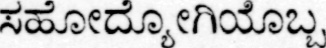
ಸಹೋದ್ಯೋಗಿಯೊಬ್ಬ
